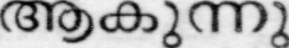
ആകുന്നു
